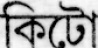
কিটো
